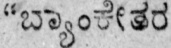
“ಬ್ಯಾಂಕೇತರ
